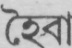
হৈবা
